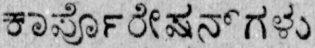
ಕಾರ್ಪೋರೇಷನ್‌ಗಳು
